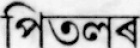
পিতলৰ
